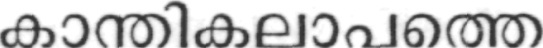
കാന്തികലാപത്തെ
